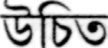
উচিত
